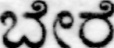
ಬೇರೆ
